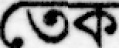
তেক
